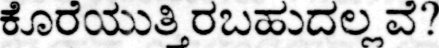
ಕೊರೆಯುತ್ತಿರಬಹುದಲ್ಲವೆ?
